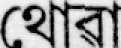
থোৱা
